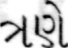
ત્રણે
